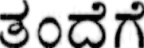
ತಂದೆಗೆ
